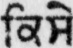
ਕਿਸੇ
